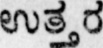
ಉತ್ತರ
